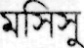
মসিসু
